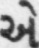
એ
